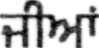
ਜੀਆਂ
